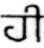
ਹੀ
